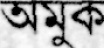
অমুক
